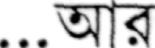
...আর
